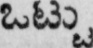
ಒಟ್ಟು
